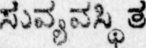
ಸುವ್ಯವಸ್ಥಿತ
